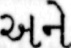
અને
